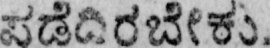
ಪಡೆದಿರಬೇಕು.
